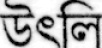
উৎলি
